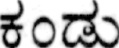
ಕಂಡು
